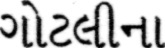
ગોટલીના
